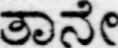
ತಾನೇ
